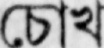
চোখ
